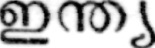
ഇന്ത്യ
